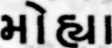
મોહ્યા
